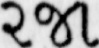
રજા
